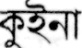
কুইনা
